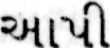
આપી
